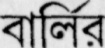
বার্লির
